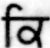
ਕਿ
